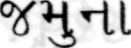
જમુના
